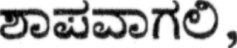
ಶಾಪವಾಗಲಿ,
